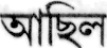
আছিল
